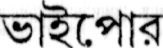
ভাইপোর
